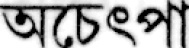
অচেৎপা
